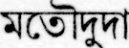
মতৌদুদা
